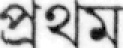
প্রথম
